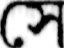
সে
